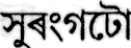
সুৰংগটো
